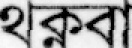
থক্নবা
